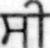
ਸੀ
